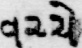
વચ્ચે
